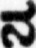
ನ
